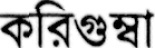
করিগুম্বা
